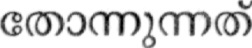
തോന്നുന്നത്
